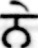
ਨੇ
